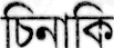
চিনাকি
